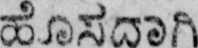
ಹೊಸದಾಗಿ
